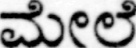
ಮೇಲೆ
